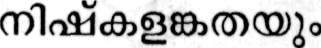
നിഷ്കളങ്കതയും
